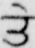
ਤੇ
